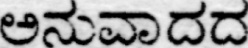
ಅನುವಾದದ
